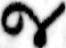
જ
